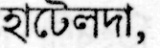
হোটেলদা,
